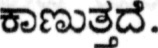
ಕಾಣುತ್ತದೆ.
